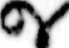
જ
